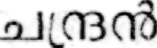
ചന്ദ്രന്‍
